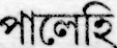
পালেহি
